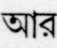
আর
